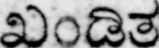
ಖಂಡಿತ
